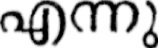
എന്നു
